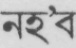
নহ'ব
